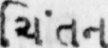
ચિંતન
